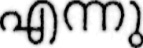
എന്നു
